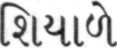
શિયાળે
